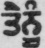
ਤੈਨੂੰ
